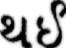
થઈ
